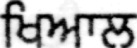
ਖ਼ਿਆਲ
